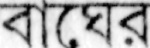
বাঘের
